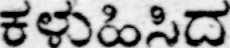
ಕಳುಹಿಸಿದ
